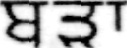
ਬੜਾ
